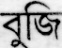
বুজি
